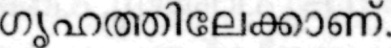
ഗൃഹത്തിലേക്കാണ്.
